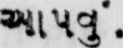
આપવું.
